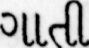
ગાતી
